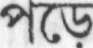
পড়ে
